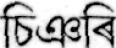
চিঞৰি
